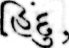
હિંદુ,
